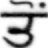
ਤੋਂ
